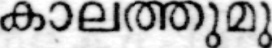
കാലത്തുമു
